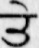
ਤੇ
